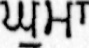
ਘੁਮਾ
